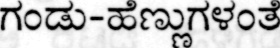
ಗಂಡು-ಹೆಣ್ಣುಗಳಂತೆ
